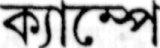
ক্যাম্পে
